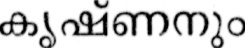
കൃഷ്ണനും
